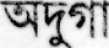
অদুগা
